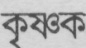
কৃষ্ণক
